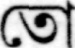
তো
